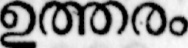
ഉത്തരം
